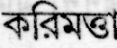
করিমত্তা
